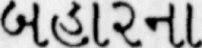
બહારના
